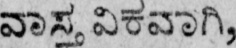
ವಾಸ್ತವಿಕವಾಗಿ,
